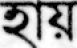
হায়
